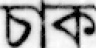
চাক
